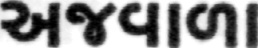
અજવાળા
